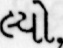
લ્યો,
